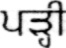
ਪੜ੍ਹੀ
